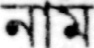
নাম
